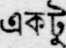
একটু
